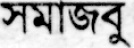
সমাজবু
